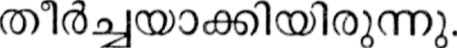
തീര്‍ച്ചയാക്കിയിരുന്നു.
